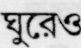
ঘুরেও
